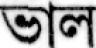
ভাল
